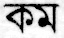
কম
